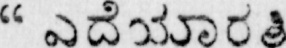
“ಎದೆಯಾರತಿ
